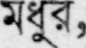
মধুর,
